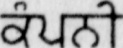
ਕੰਪਨੀ
